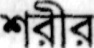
শরীর
